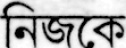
নিজকে
